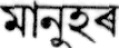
মানুহৰ
